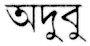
অদুবু
